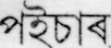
পইচাৰ
